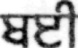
ਬਈ
